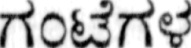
ಗಂಟೆಗಳ
